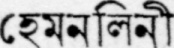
হেমনলিনী
